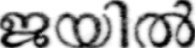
ജയില്‍
